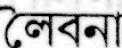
লৈবনা
